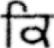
ਕਿ
